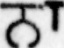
ਨਾ''
